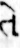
તે
